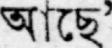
আছে’
